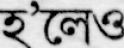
হ'লেও
